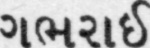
ગભરાઈ
